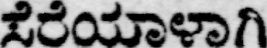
ಸೆರೆಯಾಳಾಗಿ
